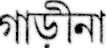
গাড়ীনা
